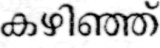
കഴിഞ്ഞ്
